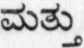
ಮತ್ತು
